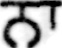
ਨਾ
